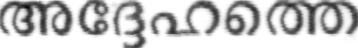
അദ്ദേഹത്തെ
